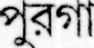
পুরগা
